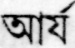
আর্য
